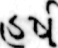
હર્ષ
